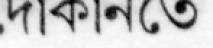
দোকানতে
